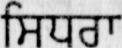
ਸਿਧਰਾ
